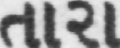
તારા
